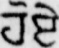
ਹੋਏ
